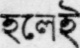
হলেই
